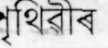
পৃথিৱীৰ
